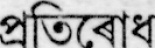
প্রতিৰোধ
